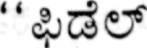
"ಫಿಡೆಲ್
